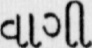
વાગી
